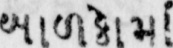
બાળકોમાં
